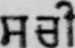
ਸਚੀ
